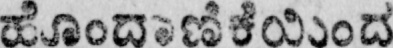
ಹೊಂದಾಣಿಕೆಯಿಂದ
